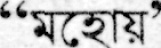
“মহোয়’
